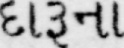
દારૂના
